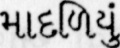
માદળિયું
